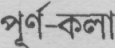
পূৰ্ণ-কলা
